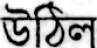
উঠিল
